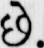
છે.
